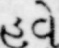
હવે
